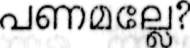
പണമല്ലേ?
